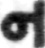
ન
